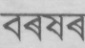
বৰষৰ
